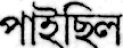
পাইছিল
